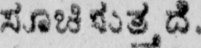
ಸೂಚಿಸುತ್ತದೆ.
